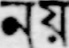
নয়
